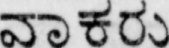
ವಾಕರು
